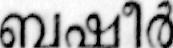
ബഷീര്‍
